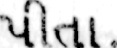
પીતા.
